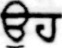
ਉਹ
